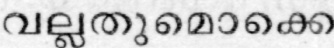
വല്ലതുമൊക്കെ
